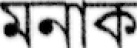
মনাক
